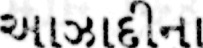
આઝાદીના
